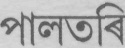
পালতৰি
